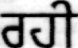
ਰਹੀ
